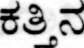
ಕತ್ತಿನ
